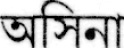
অসিনা
